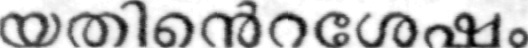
യതിന്റെശേഷം
